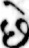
છે
